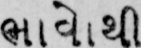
ભાવોથી
